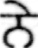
ਨੇ
